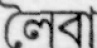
লৈবা
